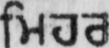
ਮਿਹਰ
